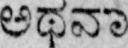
ಅಥವಾ
